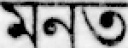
মনত
